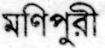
মণিপুরী
